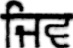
ਜਿਵ
